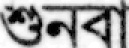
শুনবা
